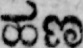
ಹಣ
